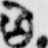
છે.
